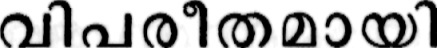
വിപരീതമായി
